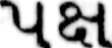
પક્ષ
